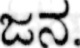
ಜನ.
